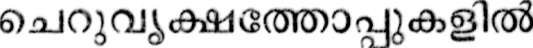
ചെറുവൃക്ഷത്തോപ്പുകളില്‍
